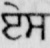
ਏਸ
